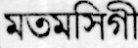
মতমসিগী
